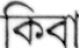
কিবা
